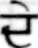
ਦੇ
